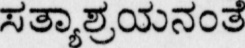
ಸತ್ಯಾಶ್ರಯನಂತೆ
